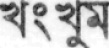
খংখুম
